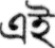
এই
